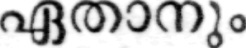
ഏതാനും
